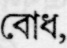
বোধ,
